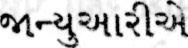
જાન્યુઆરીએ
